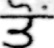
ਤੋਂ
